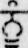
ਨੂੰ
